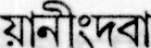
য়ানীংদবা
